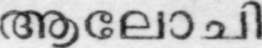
ആലോചി
